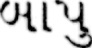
બાપુ
